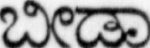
ಬೀಡಾ
